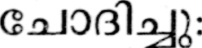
ചോദിച്ചു:
